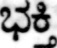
ಭಕ್ತಿ
